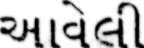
આવેલી
